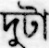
দুটা
